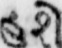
હશે
